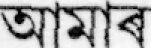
আমাৰ
